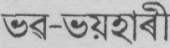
ভৱ-ভয়হাৰী
